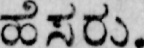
ಹೆಸರು.
